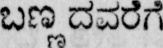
ಬಣ್ಣದವರೆಗೆ
